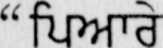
''ਪਿਆਰੇ
